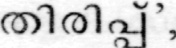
തിരിപ്പ്’,
